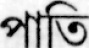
পাতি
